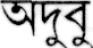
অদুবু
